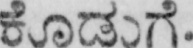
ಕೊಡುಗೆ.
